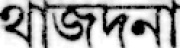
থাজদনা
